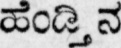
ಹೆಂಡ್ತಿನ
